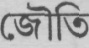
জৌতি
